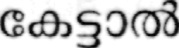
കേട്ടാല്‍
